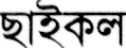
ছাইকল
